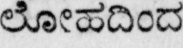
ಲೋಹದಿಂದ
